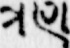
ત્રણ
